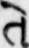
તે
